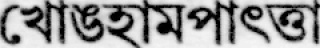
খোঙহামপাৎত্তা
